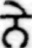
ਨੇ
